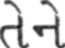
તેને
